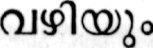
വഴിയും
